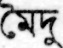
মৈদু
